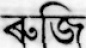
ৰুজি
